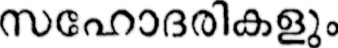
സഹോദരികളും
